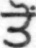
ਤੋਂ
